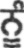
ਨੂੰ
